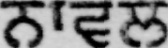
ਨਾਵਲ
